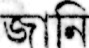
জানি
